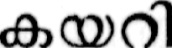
കയറി
